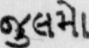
જુલમો
